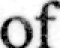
of
